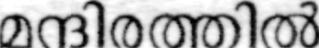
മന്ദിരത്തില്‍
